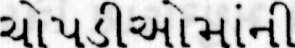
ચોપડીઓમાંની
